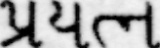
પ્રયત્ન
